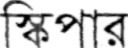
স্কিপার
